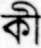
কী
